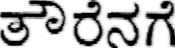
ತೌರೆನಗೆ
